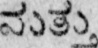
ಮತ್ತು
